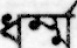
ধর্ম্ম
